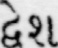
દ્વેશ
